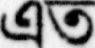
এত
